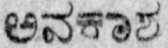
ಅವಕಾಶ
